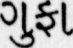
ગુફા
